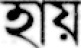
হায়
